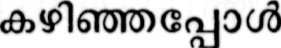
കഴിഞ്ഞപ്പോള്‍
